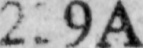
2.9A
